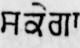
ਸਕੇਗਾ
